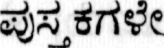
ಪುಸ್ತಕಗಳೇ
